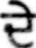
ਦੇ
